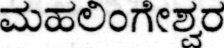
ಮಹಲಿಂಗೇಶ್ವರ
